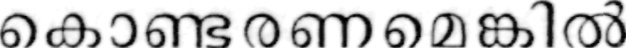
കൊണ്ടരണമെങ്കില്‍
